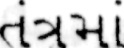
તંત્રમાં
